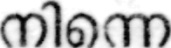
നിന്നെ
